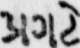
પ્રગટે
